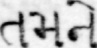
તમને
